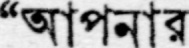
‘‘আপনার
